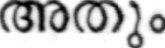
അതും
